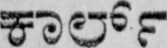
ಕಾರ್ಲ್
